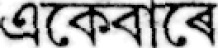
একেবাৰে
